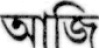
আজি
